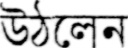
উঠলেন
